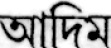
আদিম
